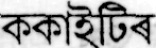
ককাইটিৰ
